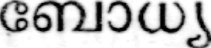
ബോധ്യ
